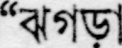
‘‘ঝগড়া
